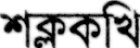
শক্লকখি
